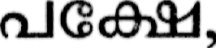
പക്ഷേ,
